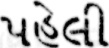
પહેલી
